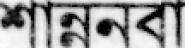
শান্ননবা
